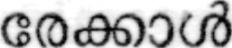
രേക്കാള്‍
